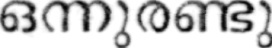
ഒന്നുരണ്ടു
